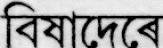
বিষাদেৰে
